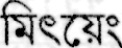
মিৎয়েং
